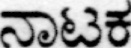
ನಾಟಕ
